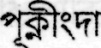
পূক্নীংদা
